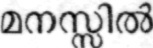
മനസ്സില്‍
